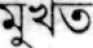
মুখত
